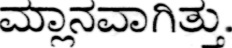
ಮ್ಲಾನವಾಗಿತ್ತು.
